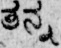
ತನ್ನ
